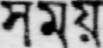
সময়
